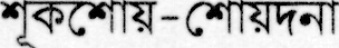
শূকশোয়-শোয়দনা
